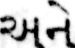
અને
